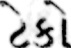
ટેકો
